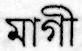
মাগী
